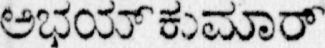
ಅಭಯ್‌ಕುಮಾರ್
